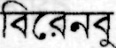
বিরেনবু
